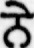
ਨੇ
